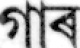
গাৰ
